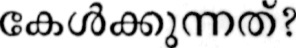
കേള്‍ക്കുന്നത്?
